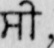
ਸੀ,
